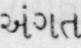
અંગત
